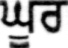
ਘੂਰ
